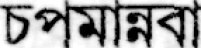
চপমান্নবা
